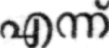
എന്ന്
